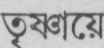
তৃষ্ণায়ে
